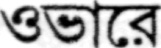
ওভারে
